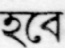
হবে
